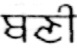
ਬਣੀ
